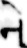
ને
